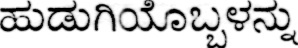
ಹುಡುಗಿಯೊಬ್ಬಳನ್ನು
